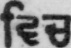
ਵਿਚ
